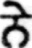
ਨੇ
